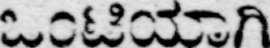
ಒಂಟಿಯಾಗಿ
